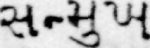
સન્મુખ
